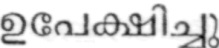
ഉപേക്ഷിച്ചു
